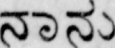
ನಾನು
